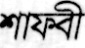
শাফবী
